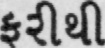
ફરીથી
